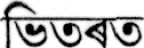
ভিতৰত
